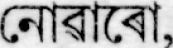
নোৱাৰো,
